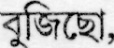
বুজিছো,
